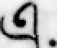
এ.
